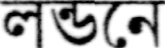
লন্ডনে
